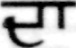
ਦਾ
